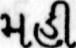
મહી
